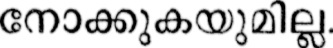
നോക്കുകയുമില്ല.
